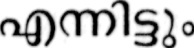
എന്നിട്ടും
